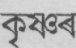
কৃষ্ণৰ
